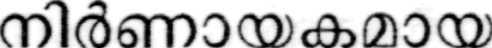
നിര്‍ണായകമായ
